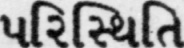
પરિસ્થિતિ
